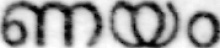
ണയം
